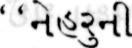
"નેહરુની
